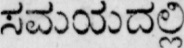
ಸಮಯದಲ್ಲಿ
